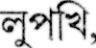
লুপখি,
